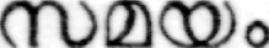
സമയം
